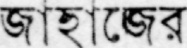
জাহাজের
